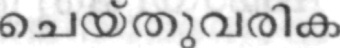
ചെയ്തുവരിക
